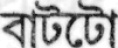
বাটটো
